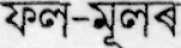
ফল-মূলৰ
